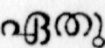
ഏതു
